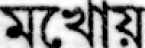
মখোয়
